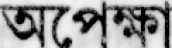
অপেক্ষা
